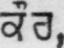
ਕੌਰ,
